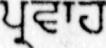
ਪ੍ਰਵਾਹ
